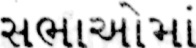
સભાઓમાં
